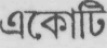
একোটি
